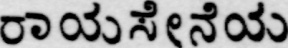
ರಾಯಸೇನೆಯ
